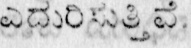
ಎದುರಿಸುತ್ತಿವೆ.
